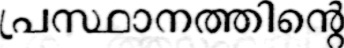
പ്രസ്ഥാനത്തിന്റെ
